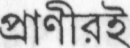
প্রাণীরই
